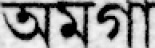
অমগা
